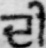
ਦੀ
